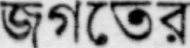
জগতের
